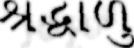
શ્રદ્ધાળુ
